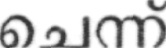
ചെന്ന്
